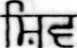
ਸ਼ਿਵ
